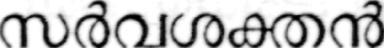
സര്‍വശക്തന്‍
